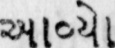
આવ્યો
